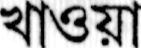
খাওয়া
